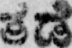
ತಡೆ
